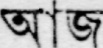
আজ
